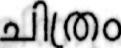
ചിത്രം
